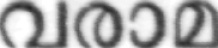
വരാമ
